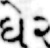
ઘેર
